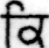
ਕਿ
